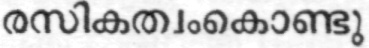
രസികത്വംകൊണ്ടു
